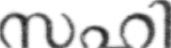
സഹി
